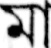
মা
